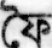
ফৈ
